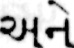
અને
